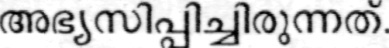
അഭ്യസിപ്പിച്ചിരുന്നത്.
